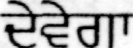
ਦੇਵੇਗਾ
